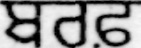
ਬਰਫ਼
